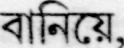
বানিয়ে,
